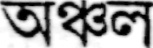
অঞ্চল
